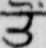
ਤੋਂ
